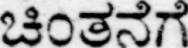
ಚಿಂತನೆಗೆ
